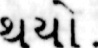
થયો.
